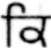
ਕਿ
